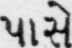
પાસે
